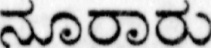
ನೂರಾರು
